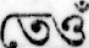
তেওঁ
